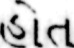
હોત
